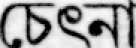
চেৎনা
